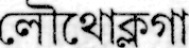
লৌথোক্লগা
